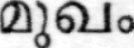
മുഖം
